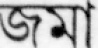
জমা
